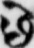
છે
